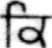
ਕਿ
